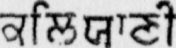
ਕਲਿਯਾਣੀ
